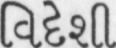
વિદેશી
